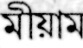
মীয়াম
